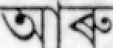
আৰু
